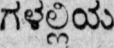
ಗಳಲ್ಲಿಯ
